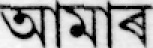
আমাৰ
